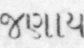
જણાય
